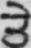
ਤੇ
